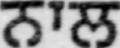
ਨਾਲ
